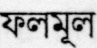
ফলমূল
